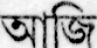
আজি
